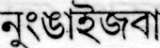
নুংঙাইজবা
